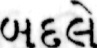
બદલે
